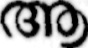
ആ
